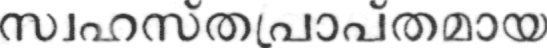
സ്വഹസ്തപ്രാപ്തമായ
